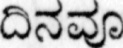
ದಿನವೂ
